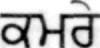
ਕਮਰੇ
